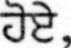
ਹੋਏ,
